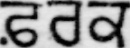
ਫ਼ਰਕ
